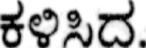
ಕಳಿಸಿದ.
